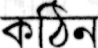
কঠিন
